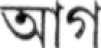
আগ
